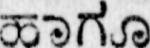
ಹಾಗೂ
